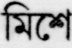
মিশে
